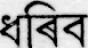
ধৰিব
